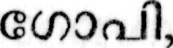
ഗോപി,
